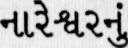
નારેશ્વરનું
